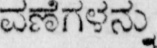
ವಣೆಗಳನ್ನು
